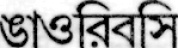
ঙাওরিবসি
